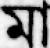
মা
